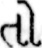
તો
